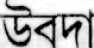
উবদা
